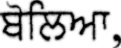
ਬੋਲਿਆ,
